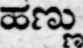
ಹಣ್ಣು
